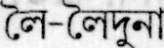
লৈ-লৈদুনা
